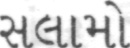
સલામો
